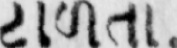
ટાળતા.
